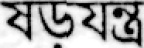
ষড়যন্ত্র
